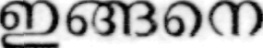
ഇങ്ങനെ
